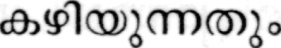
കഴിയുന്നതും
